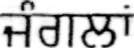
ਜੰਗਲਾਂ
